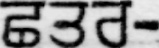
ਛਤਰ-
